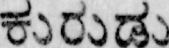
ಕುರುಡು
